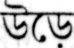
উড়ে
